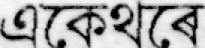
একেথৰে
